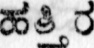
ಹತ್ತಿರ
